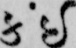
કંઈ
